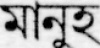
মানুহ
